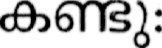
കണ്ടു:
